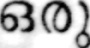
ഒരു
